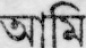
আমি
